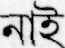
নাই
